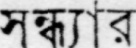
সন্ধ্যার
